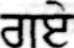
ਗਏ
